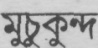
মুচুকুন্দ
